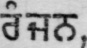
ਰੰਜਨ,
